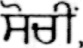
ਸੋਚੀਂ,
